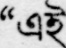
‘‘এই
